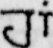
ਹਾਂ
